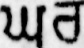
ਘਰ
